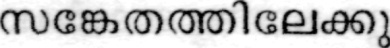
സങ്കേതത്തിലേക്കു
